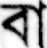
বা
